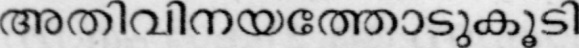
അതിവിനയത്തോടുകൂടി
